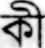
কী
